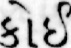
કોઇ
